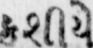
કશીયે
